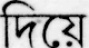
দিয়ে
